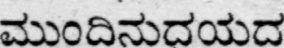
ಮುಂದಿನುದಯದ
